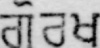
ਗੋਰਖ
